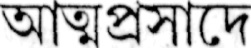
আত্মপ্রসাদে
